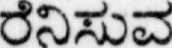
ರೆನಿಸುವ
